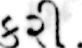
કરી.
